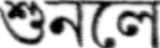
শুনলে
